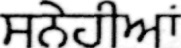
ਸਨੇਹੀਆਂ
